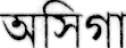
অসিগা
